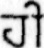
ਹੀ
